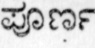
ಪೂರ್ಣ
